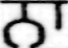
ਨਾ
